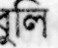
বুলি
